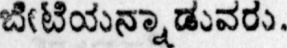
ಬೇಟೆಯನ್ನಾಡುವರು.
